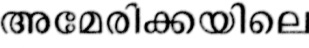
അമേരിക്കയിലെ
